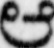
ಆ
